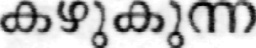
കഴുകുന്ന
